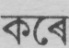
কৰে
